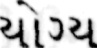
યોગ્ય
